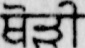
ਥੋੜੀ
